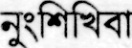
নুংশিখিবা
